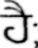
ਹੈ;
